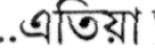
...এতিয়া
